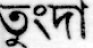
তুংদা
